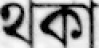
থকা
